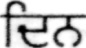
ਦਿਨ
